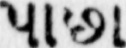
પાછા
